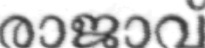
രാജാവ്
